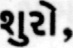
શુરો,
